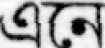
এনে
